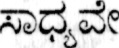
ಸಾಧ್ಯವೇ
